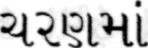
ચરણમાં
